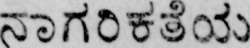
ನಾಗರಿಕತೆಯ
